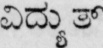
ವಿದ್ಯುತ್
